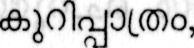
കുറിപ്പാത്രം,
